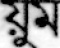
য়ুম
